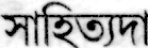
সাহিত্যদা
